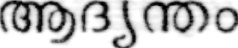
ആദ്യന്തം
